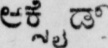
ಆಕ್ಸೈಡ್
